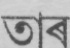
তাৰ
